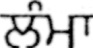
ਲੰਮਾ
